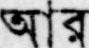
আর
